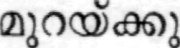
മുറയ്ക്കു
